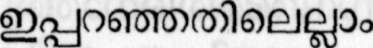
ഇപ്പറഞ്ഞതിലെല്ലാം
